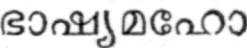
ഭാഷ്യമഹോ
